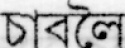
চাবলৈ
